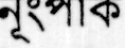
নূংপাক
